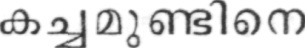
കച്ചമുണ്ടിനെ
